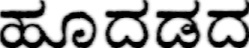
ಹೂದಡದ
